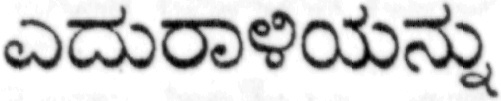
ಎದುರಾಳಿಯನ್ನು
